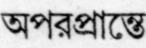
অপরপ্রান্তে
